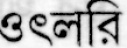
ওৎলরি
